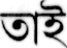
তাই
